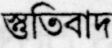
স্তুতিবাদ
